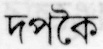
দপকৈ
